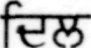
ਦਿਲ
